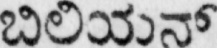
ಬಿಲಿಯನ್
